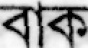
বাক
